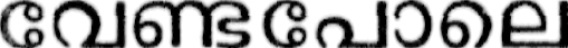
വേണ്ടപോലെ
